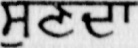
ਸੁਣਦਾ
